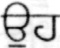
ਉਹ
